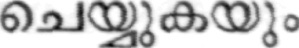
ചെയ്യുകയും
